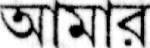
আমার
